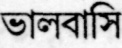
ভালবাসি
